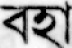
বহা
